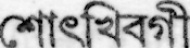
শোৎখিবগী
